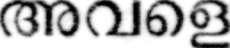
അവളെ
